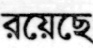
রয়েছে
